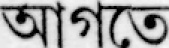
আগতে
